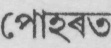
পোহৰত
